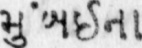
મુંબઈના
